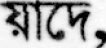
য়াদে,
